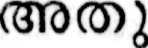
അതു
